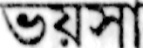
ভয়সা
